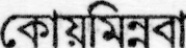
কোয়মিন্নবা
